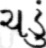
ચડું
